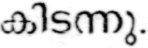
കിടന്നു.
